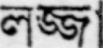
লজ্জা
